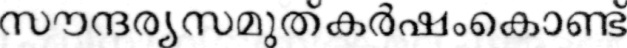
സൗന്ദര്യസമുത്കര്‍ഷംകൊണ്ട്
